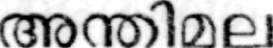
അന്തിമല
